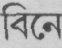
বিনে
